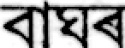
বাঘৰ
